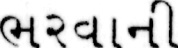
ભરવાની
